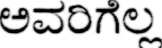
ಅವರಿಗೆಲ್ಲ
